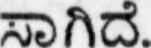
ಸಾಗಿದೆ.
